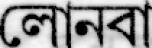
লোনবা
